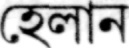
হেলান
